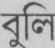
বুলি
